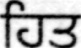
ਹਿਤ
